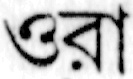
ওরা
